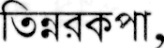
তিন্নরকপা,
